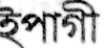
ইপাগী
